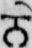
ਨੇ
